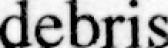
debris
